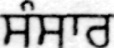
ਸੰਸਾਰ
